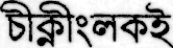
চীক্নীংলকই
